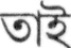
তাই
